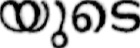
യുടെ
